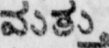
ಮತ್ತು
